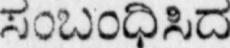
ಸಂಬಂಧಿಸಿದ
